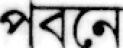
পবনে
